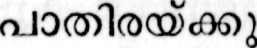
പാതിരയ്ക്കു
